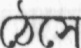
ঠেসে
